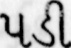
પડી
